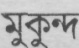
মুকুন্দ
